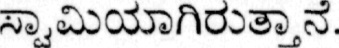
ಸ್ವಾಮಿಯಾಗಿರುತ್ತಾನೆ.
